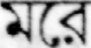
মরে
